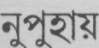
নুপুহায়
